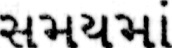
સમયમાં
